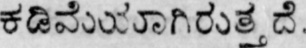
ಕಡಿಮೆಯಾಗಿರುತ್ತದೆ.
